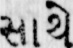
સાથે
